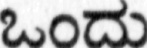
ಒಂದು
